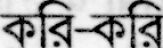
করি-করি
